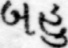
બહુ
